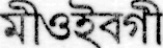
মীওইবগী
